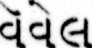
વૅવેલ
